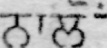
ਨਾਲੋਂ
